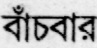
বাঁচবার
